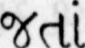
જતાં
